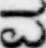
ವ
